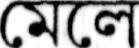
মেলে
